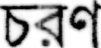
চরণ
